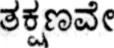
ತಕ್ಷಣವೇ
